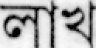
লাখ
